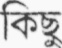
কিছু
